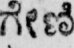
ಗೇಣಿ
